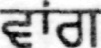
ਵਾਂਗ
